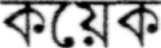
কয়েক
